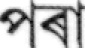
পৰা
